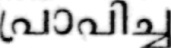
പ്രാപിച്ച
